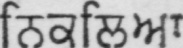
ਨਿਕਲਿਆ
